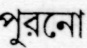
পুরনো
